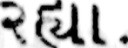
રહ્યા.
